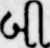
બી
